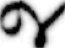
જ
